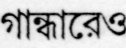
গান্ধারেও
